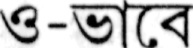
ও-ভাবে
